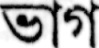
ভাগ
